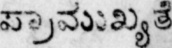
ಪ್ರಾಮುಖ್ಯತೆ
